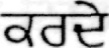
ਕਰਦੇ
